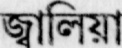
জ্বালিয়া
